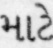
માટે
